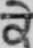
ਕੇ
